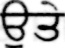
ਉਤੇ
